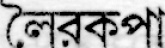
লৈরকপা
